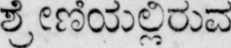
ಶ್ರೇಣಿಯಲ್ಲಿರುವ
